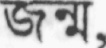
জন্ম,
